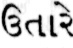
ઉતારે
